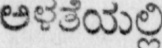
ಅಳತೆಯಲ್ಲಿ
